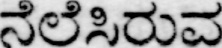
ನೆಲೆಸಿರುವ
